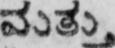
ಮತ್ತು
